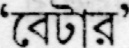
‘বেটার’
